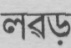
লৱড়
